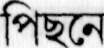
পিছনে
